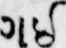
ગઈ
